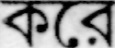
করে
